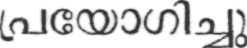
പ്രയോഗിച്ചു
